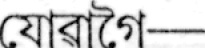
যোৱাগৈ-
